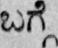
ಬಗ್ಗೆ
